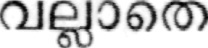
വല്ലാതെ
